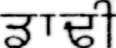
ਡਾਢੀ
